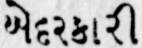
બેદરકારી
